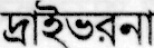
দ্রাইভরনা
